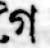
গৈ
